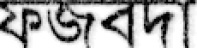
ফজবদা
